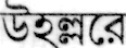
উহল্লরে
